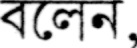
বলেন,
